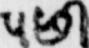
પછી
